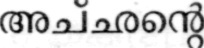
അച്ഛന്റെ
